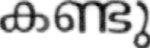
കണ്ടു
